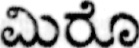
ಮಿರೊ
